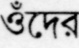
ওঁদের
